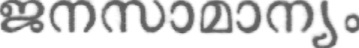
ജനസാമാന്യം
